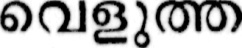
വെളുത്ത
